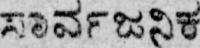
ಸಾರ್ವಜನಿಕ
